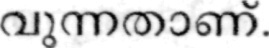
വുന്നതാണ്.
